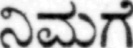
ನಿಮಗೆ
